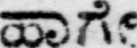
ಹಾಗೇ
